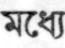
মধ্যে
